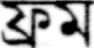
ফ্রম
